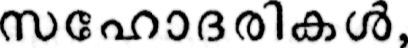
സഹോദരികള്‍,
